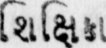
શિક્ષિકા
